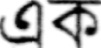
এক
